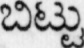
ಬಿಟ್ಟು
